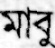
মাবু
